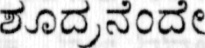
ಶೂದ್ರನೆಂದೇ
